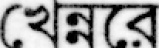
খেন্নরে
